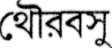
থৌরবসু
